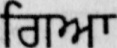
ਗਿਆ
